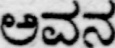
ಅವನ
